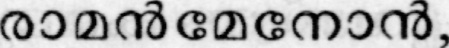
രാമന്‍മേനോന്‍,
